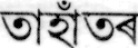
তাহাঁতৰ
